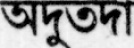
অদুতদা
